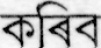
কৰিব
